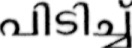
പിടിച്ച്
